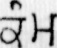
ਕੰਮ
